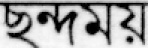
ছন্দময়
